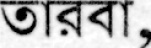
তারবা,
